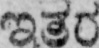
ಇತರ
